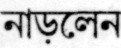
নাড়লেন
